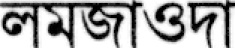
লমজাওদা
